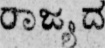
ರಾಜ್ಯದ
